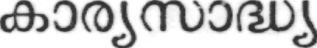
കാര്യസാദ്ധ്യ
